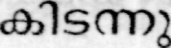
കിടന്നു
